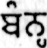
ਬੰਨ੍ਹ
